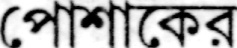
পোশাকের
